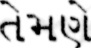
તેમણે
